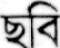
ছবি
